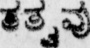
ತತ್ವವು
